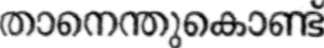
താനെന്തുകൊണ്ട്
